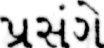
પ્રસંગે
